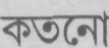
কতনো
